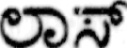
ಲಾಸ್
